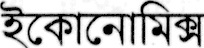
ইকোনোমিক্স
